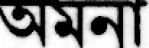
অমনা
